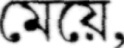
মেয়ে,
